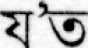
য'ত
